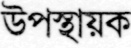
উপস্থায়ক
